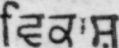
ਵਿਕਾਸ਼
